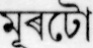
মূৰটো
